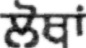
ਲੋਥਾਂ
